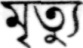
মৃত্যু
